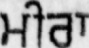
ਮੀਰਾ
